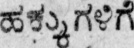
ಹಕ್ಕುಗಳಿಗೆ
